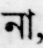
না,
